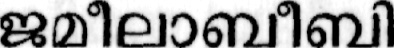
ജമീലാബീബി
